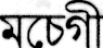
মচেগী
